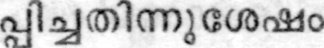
പ്പിച്ചതിന്നുശേഷം
